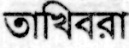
তাখিবরা
